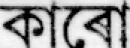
কাৰো
